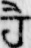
ਹੈ
